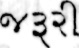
જરૂરી
